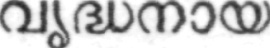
വൃദ്ധനായ
